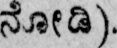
ನೋಡಿ).
